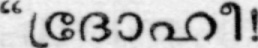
"ദ്രോഹീ!
